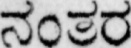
ನಂತರ
